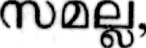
സമല്ല,
